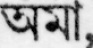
অমা,
